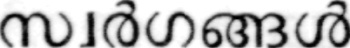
സ്വര്‍ഗങ്ങള്‍
